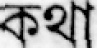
কথা
